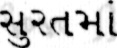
સુરતમાં
